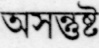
অসন্তুষ্ট
